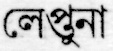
লেপ্তুনা
